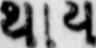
થાય
